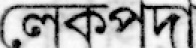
লেকপদা
